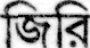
জিরি
